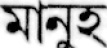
মানুহ
